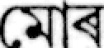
মোৰ
